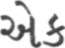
એક
